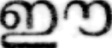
ഈ
